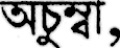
অচুম্বা,
